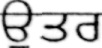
ਉਤਰ
